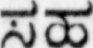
ಸಹ
